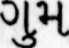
ગુમ
